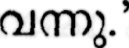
വന്നു.'
